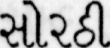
સોરઠી
